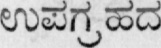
ಉಪಗ್ರಹದ
